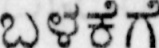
ಬಳಕೆಗೆ
